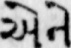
એને
